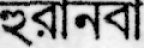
হুরানবা
